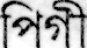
পিগী
